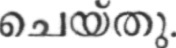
ചെയ്തു.
